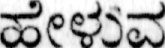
ಹೇಳುವ
